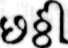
છઠ્ઠી
